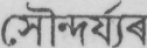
সৌন্দৰ্য্যৰ
